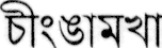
চীংঙামখা
